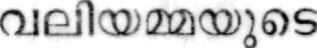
വലിയമ്മയുടെ
